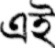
এই
